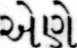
એણે
